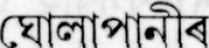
ঘোলাপানীৰ
